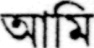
আমি
